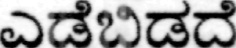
ಎಡೆಬಿಡದೆ
